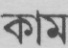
কাম
